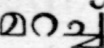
മറച്ച്
